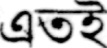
এতই
